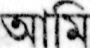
আমি
